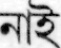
নাই
